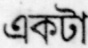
একটা
